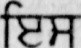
ਇਸ
